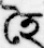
হৈ
